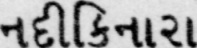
નદીકિનારા
